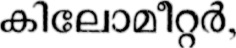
കിലോമീറ്റര്‍,
